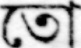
তো
